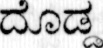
ದೊಡ್ಡ
